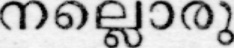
നല്ലൊരു
